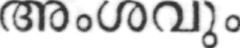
അംശവും
